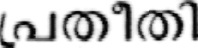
പ്രതീതി
